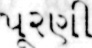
પૂરણી
